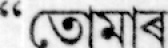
"তোমাৰ
